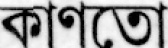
কাণতো
